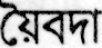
য়ৈবদা
